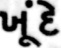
ખૂંદે
